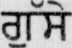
ਗੁੱਸੇ
